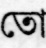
তো
